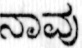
ನಾವು
